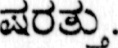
ಷರತ್ತು.
